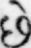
છે
